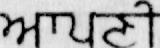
ਆਪਣੀ
